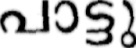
പാട്ടു
